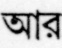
আর
